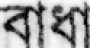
বাধা
